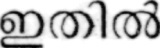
ഇതില്‍
